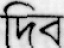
দিব
